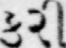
કરી
